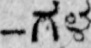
-ಗಳ
